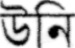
উনি
